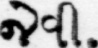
જેવી.
